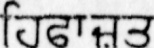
ਹਿਫਾਜ਼ਤ
